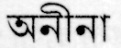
অনীনা
